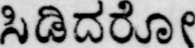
ಸಿಡಿದರೋ
